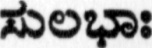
ಸುಲಭಾಃ
